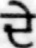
ਦੇ
